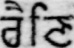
ਰੈਣਿ
